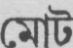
মোট
